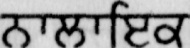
ਨਾਲਾਇਕ
